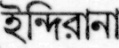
ইন্দিরানা
